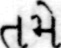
તમે
